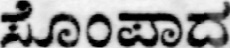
ಸೊಂಪಾದ
